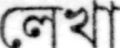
লেখা
